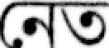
নেত
